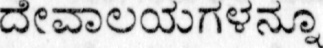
ದೇವಾಲಯಗಳನ್ನೂ
